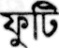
ফুটি
